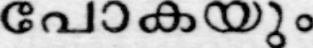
പോകയും
